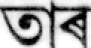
তাৰ
